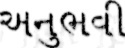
અનુભવી
